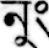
নুং
